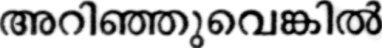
അറിഞ്ഞുവെങ്കില്‍
